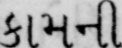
કામની
